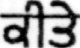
ਕੀਤੇ
